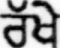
ਰੱਖੇ
